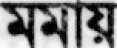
মমায়
